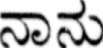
ನಾನು
